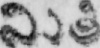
ಮಿತಿ
